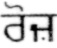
ਰੋਜ਼
